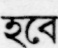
হবে
